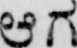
ಆಗ
